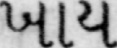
ખાય
